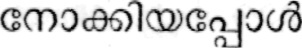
നോക്കിയപ്പോള്‍
